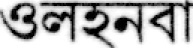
ওলহনবা
